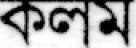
কলম
